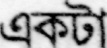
একটা
